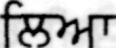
ਲਿਆ
